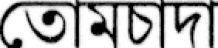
তোমচাদা
